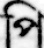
পি
